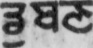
ਡੁਬਣ
